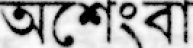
অশেংবা
